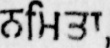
ਨਮਿਤਾ,
